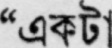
‘‘একটা
